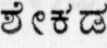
ಶೇಕಡ
